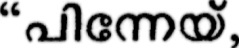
“പിന്നേയ്,
